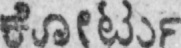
ಕೋರ್ಟು
